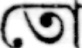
তো
